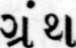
ગ્રંથ
